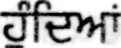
ਹੁੰਦਿਆਂ
